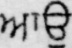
ਆਉ
